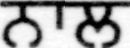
ਨਾਲ
